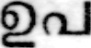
ഉപ
